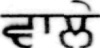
ਵਾਲੇ
